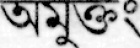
অমুক্তং
